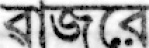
ৱাজরে
